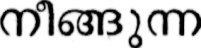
നീങ്ങുന്ന
